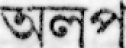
অলপ
